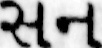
સન
